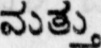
ಮತ್ತು
